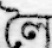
লৈ
